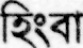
হিংবা
